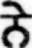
ਨੇ
